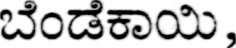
ಬೆಂಡೆಕಾಯಿ,
